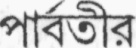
পার্বতীর
